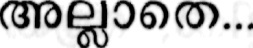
അല്ലാതെ...
